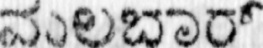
ಮಲಬಾರ್
